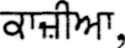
ਕਾਜ਼ੀਆ,
